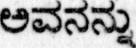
ಅವನನ್ನು
